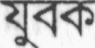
যুবক
